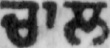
ਚਾਲ
